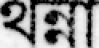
থন্না
